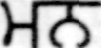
ਮਨ
